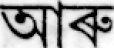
আৰু
